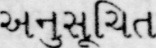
અનુસૂચિત
